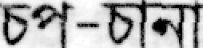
চপ-চানা
